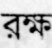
রক্ষ
